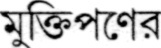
মুক্তিপণের
